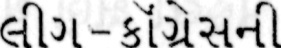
લીગ-કૉંગ્રેસની
